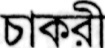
চাকরী
